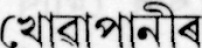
খোৱাপানীৰ
